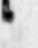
ન
